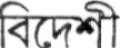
বিদেশী
